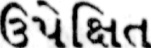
ઉપેક્ષિત
